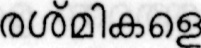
രശ്മികളെ
